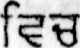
ਵਿਚ
